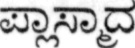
ಪ್ಲಾಸ್ಮಾದ
